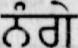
ਨੰਗੇ
